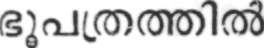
ഭൂപത്രത്തില്‍
